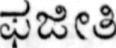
ಫಜೀತಿ
